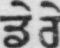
ਡੇਰੇ
